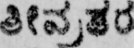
ತೀವ್ರತರ
